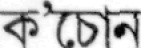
ক'চোন
